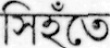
সিহঁতে
